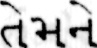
તેમને
